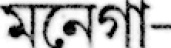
মনেগা-
